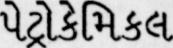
પેટ્રોકેમિકલ
